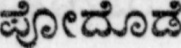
ಪೋದೊಡೆ
